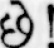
છે!
